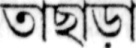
তাছাড়া
